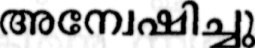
അന്വേഷിച്ചു
